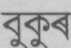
বুকুৰ
